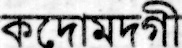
কদোমদগী
